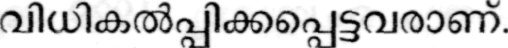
വിധികല്‍പ്പിക്കപ്പെട്ടവരാണ്.
